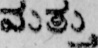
ಮತ್ತು
